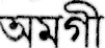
অমগী
